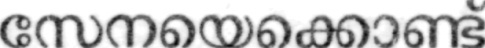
സേനയെക്കൊണ്ട്
